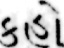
કહો
